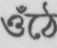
ওঁঠে
